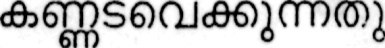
കണ്ണടവെക്കുന്നതു
